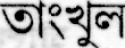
তাংখুল
